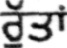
ਰੁੱਤਾਂ
